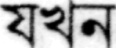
যখন
